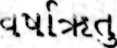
વર્ષાૠતુ
